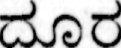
ದೂರ
